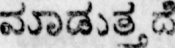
ಮಾಡುತ್ತದೆ
